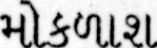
મોકળાશ
